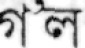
গ'ল
